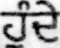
ਹੁੰਦੇ
